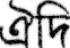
ঐদি
